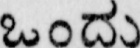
ಒಂದು
